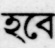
হবে
